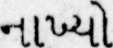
નાખ્યો
